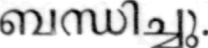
ബന്ധിച്ചു.
